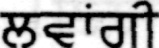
ਲਵਾਂਗੀ
